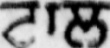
ਟਾਲ
